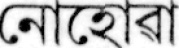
নোহোৱা
